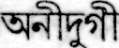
অনীদুগী
